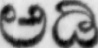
ಅಡಿ
